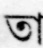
তা
